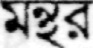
মন্থর
